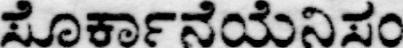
ಸೊರ್ಕಾನೆಯೆನಿಸಂ
